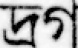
দ্রগ
